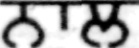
ਨਾਲ
